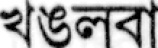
খঙলবা
